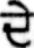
ਦੇ
